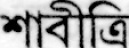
শাবীত্রি
